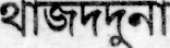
থাজদদুনা
